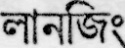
লানজিং
